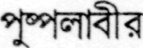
পুষ্পলাবীর
